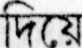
দিয়ে
